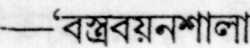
–‘বস্ত্রবয়নশালা
